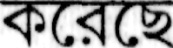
করেছে
